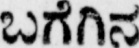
ಬಗೆಗಿನ
